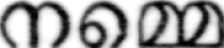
നമ്മെ
